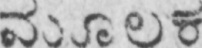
ಮೂಲಕ
